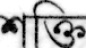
শক্তি
